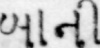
બાની
